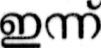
ഇന്ന്
